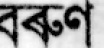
বৰুণ
